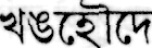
খঙহৌদে
